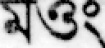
মওং
